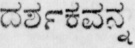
ದರ್ಶಕವನ್ನ
